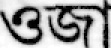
ওজা
